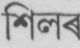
শিলৰ
